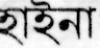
হায়না
